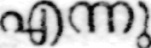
എന്നു
